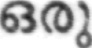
ഒരു
